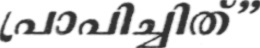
പ്രാപിച്ചിത്"
